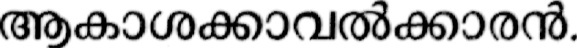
ആകാശക്കാവല്‍ക്കാരന്‍.
